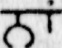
ਨਾਂ
